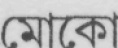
মোকো
